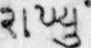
રાખ્યું
